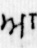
ਆ
